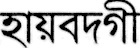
হায়বদগী
